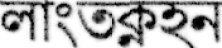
লাংতক্নহন
